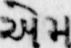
એમ
